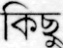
কিছু
